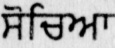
ਸੋਚਿਆ
